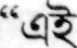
"এই
